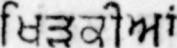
ਖਿੜਕੀਆਂ
